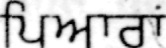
ਪਿਆਰਾਂ
